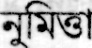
নুমিত্তা
